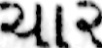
ચાર
